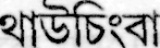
থাউচিংবা
